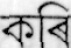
কৰি
